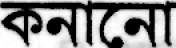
কনানো
